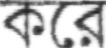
করে
